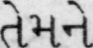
તેમને
